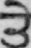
ਤੇ
